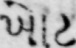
ખોટ
